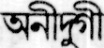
অনীদুগী
